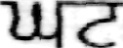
ਘਟ
